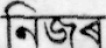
নিজৰ
